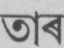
তাৰ
